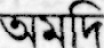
অমদি
